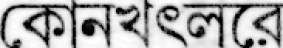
কোনখৎলরে
